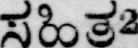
ಸಹಿತ2
